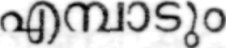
എമ്പാടും
